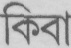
কিবা
